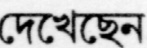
দেখেছেন
